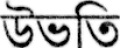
উভতি
